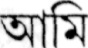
আমি
